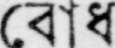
বোধ
